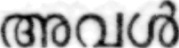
അവള്‍
